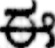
ಈ
